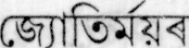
জ্যোতির্ময়ৰ
